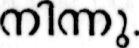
നിന്നു.
